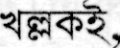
খল্লকই,
